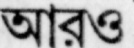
আরও
